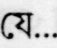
যে...
